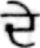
ਦੇ
